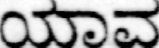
ಯಾವ
